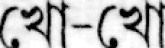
খো-খো
